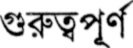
গুরুত্বপূর্ণ
